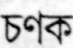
চণক
